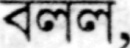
বলল,
